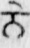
ਨੇ
